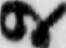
જ
